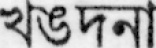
খঙদনা
